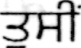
ਤੁਸੀਂ
